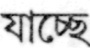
যাচ্ছে
